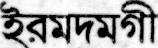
ইরমদমগী
